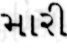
મારી
